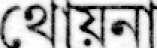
থোয়না
